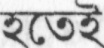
হতেই
